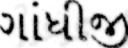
ગાંધીજી
